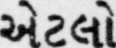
એટલો
